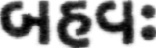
બહવઃ
